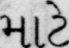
માટે
